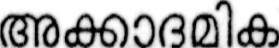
അക്കാദമിക
